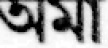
অমা
